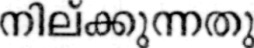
നില്ക്കുന്നതു
